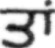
ਤਾਂ
